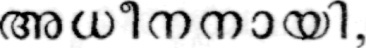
അധീനനായി,
